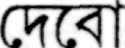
দেবো
